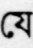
যে
